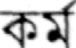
কর্ম
